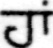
ਹਾਂ
